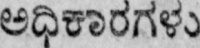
ಅಧಿಕಾರಗಳು
